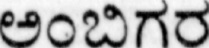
ಅಂಬಿಗರ
